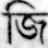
জি
